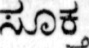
ಸೂಕ್ತ
